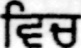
ਵਿਚ
